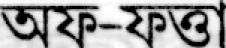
অফ-ফত্তা
